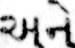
અને
